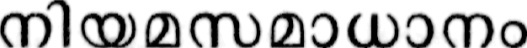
നിയമസമാധാനം
